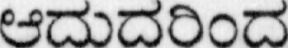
ಆದುದರಿಂದ
